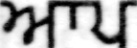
ਆਪ
